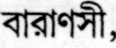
বারাণসী,
